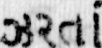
ઝરતાં
